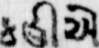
કહીએ
